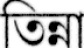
তিন্না
